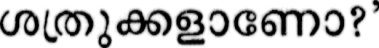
ശത്രുക്കളാണോ?’
